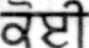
ਕੋਈ
